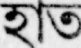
হাত
